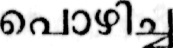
പൊഴിച്ച
